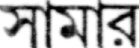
সামার
